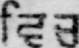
ਵਿਚ
